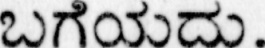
ಬಗೆಯದು.
